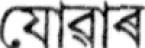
যোৱাৰ
